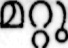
മറ്റു
